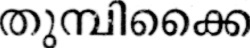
തുമ്പിക്കൈ
